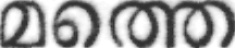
മത്തെ
